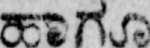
ಹಾಗೂ
